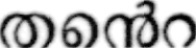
തന്റെ
